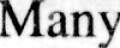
Many
